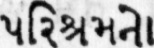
પરિશ્રમનો
